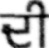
ਦੀ
